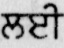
ਲਈ
